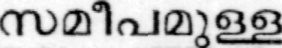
സമീപമുള്ള
